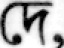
দে,
